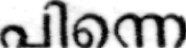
പിന്നെ
